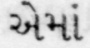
એમાં
